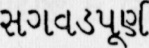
સગવડપૂર્ણ
